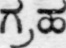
ಗ್ರಹ
